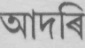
আদৰি
